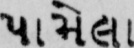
પામેલા
